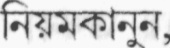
নিয়মকানুন,
